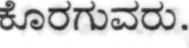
ಕೊರಗುವರು.
